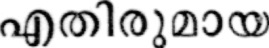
എതിരുമായ
